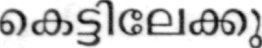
കെട്ടിലേക്കു
